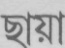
ছায়া
